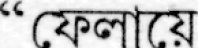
"ফেলায়ে
